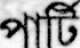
পার্টি
